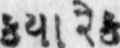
ક્યારેક
